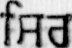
ਸਿਰ
